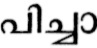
പിച്ചാ
